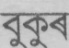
বুকুৰ
